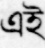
এই
